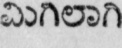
ಮಿಗಿಲಾಗಿ
